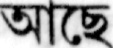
আছে
